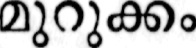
മുറുക്കം
